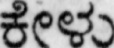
ಕೇಳು
